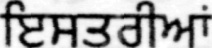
ਇਸਤਰੀਆਂ
